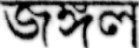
জঙ্গল
